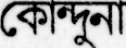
কোন্দুনা
